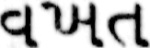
વખત
